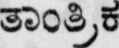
ತಾಂತ್ರಿಕ
